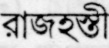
রাজহস্তী
